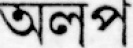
অলপ
